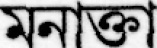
মনাক্তা
